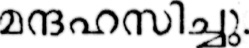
മന്ദഹസിച്ചു.
